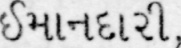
ઈમાનદારી,
